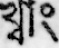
খ্বাং
